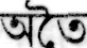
অতৈ
